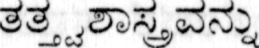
ತತ್ತ್ವಶಾಸ್ತ್ರವನ್ನು
